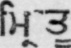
ਮ੍ਰਿਤੂ
